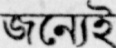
জন্যেই
